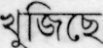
খুজিছে
